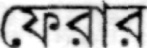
ফেরার
